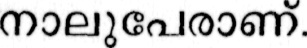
നാലുപേരാണ്.
